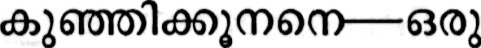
കുഞ്ഞിക്കൂനനെ-ഒരു
